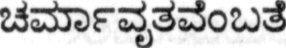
ಚರ್ಮಾವೃತವೆಂಬತೆ
